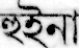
হুইনা
